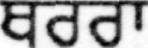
ਥਰਰਾ
